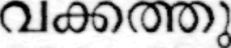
വക്കത്തു
